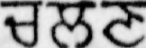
ਚਲਣ
